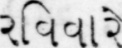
રવિવારે
